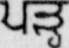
ਪੜ੍ਹ
